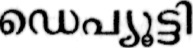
ഡെപ്യൂട്ടി
